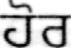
ਹੋਰ
